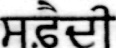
ਸਫ਼ੈਦੀ
